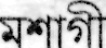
মশাগী
